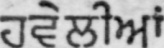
ਹਵੇਲੀਆਂ
